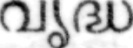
വൃദ്ധ
